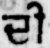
ਦੀ
